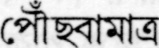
পৌঁছবামাত্র
